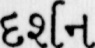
દર્શન
